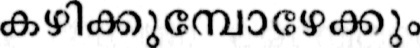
കഴിക്കുമ്പോഴേക്കും
